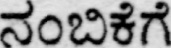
ನಂಬಿಕೆಗೆ
